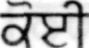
ਕੋਈ
